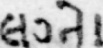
લગ્નો
